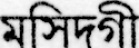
মসিদগী
